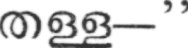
തള്ള-"
